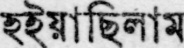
হইয়াছিলাম
